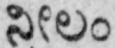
ನೀಲಂ
